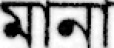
মানা
